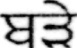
ਬੜੇ
